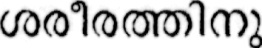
ശരീരത്തിനു
